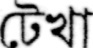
টেখা
